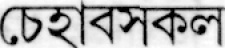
চেহাবসকল
